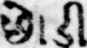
છોડી
